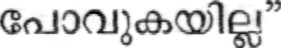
പോവുകയില്ല”
